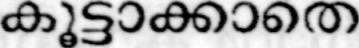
കൂട്ടാക്കാതെ
